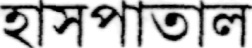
হাসপাতাল
